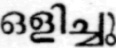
ഒളിച്ചു
